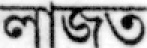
লাজত
